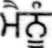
ਮੈਨੂੰ
